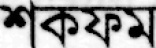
শকফম
